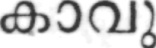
കാവു
